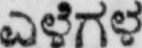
ಎಳೆಗಳ
